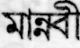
মান্নবী
